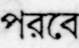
পরবে
